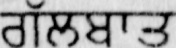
ਗੱਲਬਾਤ
